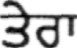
ਤੇਰਾ
